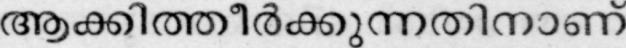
ആക്കിത്തീര്‍ക്കുന്നതിനാണ്
